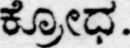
ಕ್ರೋಧ.
